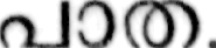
പാത.
